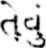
તેવું
